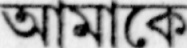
আমাকে
